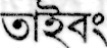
তাইবং
